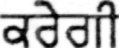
ਕਰੇਗੀ
